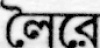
লৈরে
